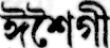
ঈশৈগী
